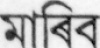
মাৰিব
